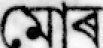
মোৰ
